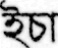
ইচা
